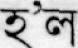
হ'ল
